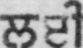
ਲਈ
